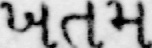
ખતમ
